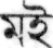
মই
